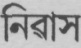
নিৱাস
